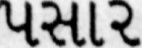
પસાર
